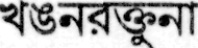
খঙনরক্তুনা
